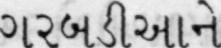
ગરબડીઆને
